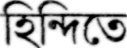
হিন্দিতে
